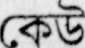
কেউ
